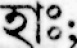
হাঃ;
